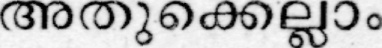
അതുക്കെല്ലാം
